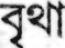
বৃথা
